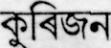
কুৰিজন
